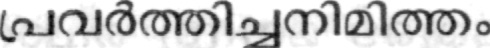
പ്രവര്‍ത്തിച്ചനിമിത്തം
